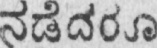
ನಡೆದರೂ
